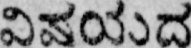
ವಿಷಯದ
